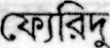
ফ্যেরিদু
